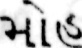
મોહ
